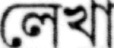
লেখা
